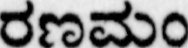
ರಣಮಂ
